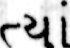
ત્યાં
